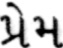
પ્રેમ
